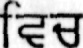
ਵਿਚ
